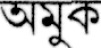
অমুক
